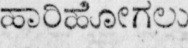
ಹಾರಿಹೋಗಲು
